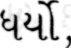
ધર્યો,
